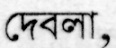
দেবলা,
